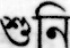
শুনি
